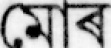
মোৰ
